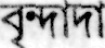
বৃন্দাদা
